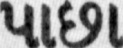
પાછા
